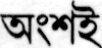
অংশই
